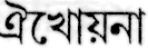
ঐখোয়না
